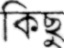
কিছু
